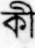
কী
